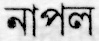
নাপল
